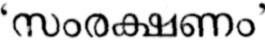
‘സംരക്ഷണം'
